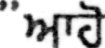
''ਆਹੋ
